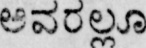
ಅವರಲ್ಲೂ
